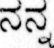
ನನ್ನ
